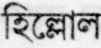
হিল্লোল
